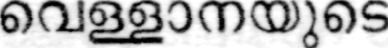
വെള്ളാനയുടെ
